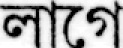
লাগে
